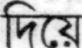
দিয়ে
